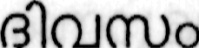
ദിവസം
